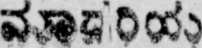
ಮಾದರಿಯ
